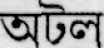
অটল
